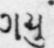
ગયું
